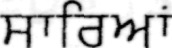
ਸਾਰਿਆਂ
